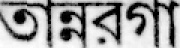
তান্নরগা
